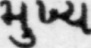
મુખ્ય
